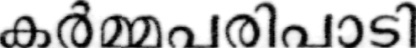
കര്‍മ്മപരിപാടി
